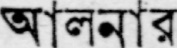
আলনার
